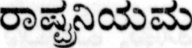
ರಾಷ್ಟ್ರನಿಯಮ
